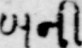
બની
